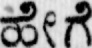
ಹೇಗೆ
